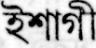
ইশাগী
